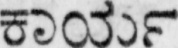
ಕಾರ್ಯ
